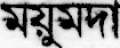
ময়ুমদা
